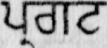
ਪ੍ਰਗਟ
